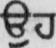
ਉਹ
